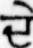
ਦੇ
